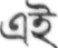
এই
